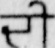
ਦੀ
